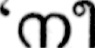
‘നീ
